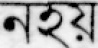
নহয়
